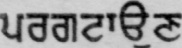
ਪਰਗਟਾਉਣ
